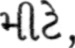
મીટે
